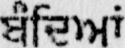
ਬੰਦਿਆਂ
